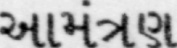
આમંત્રણ
